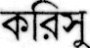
করিসু
